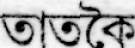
তাতকৈ
